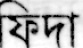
ফিদা
